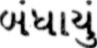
બંધાયું
